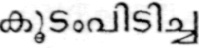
കൂടംപിടിച്ച
